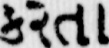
કરતા
